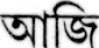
আজি
